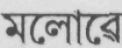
মলোৱে
